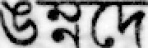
ঙম্নদে
